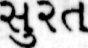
સુરત
